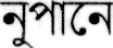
নুপানে
